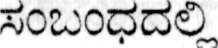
ಸಂಬಂಧದಲ್ಲಿ
